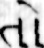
તો
